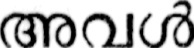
അവള്‍
